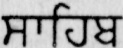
ਸਾਹਿਬ
